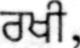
ਰਖੀ,
